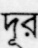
দূর
